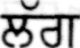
ਲੱਗ
